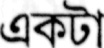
একটা
